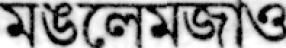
মঙলেমজাও
